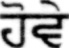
ਹੋਵੇ
